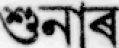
শুনাৰ
